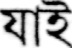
যাই
